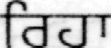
ਰਿਹਾ
